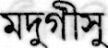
মদুগীসু
